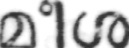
മീശ
